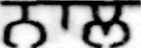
ਨਾਲ
